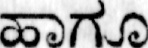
ಹಾಗೂ
